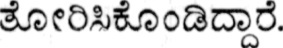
ತೋರಿಸಿಕೊಂಡಿದ್ದಾರೆ.
